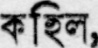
কহিল,
